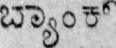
ಬ್ಯಾಂಕ್
